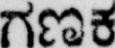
ಗಣಕ
